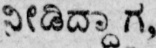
ನೀಡಿದ್ದಾಗ,
